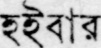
হইবার
